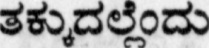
ತಕ್ಕುದಲ್ಲೆಂದು
